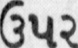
ઉપર
